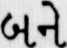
બને
